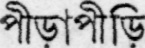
পীড়াপীড়ি
